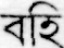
বহি
